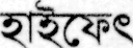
হাইফেৎ
